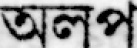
অলপ
